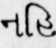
નહિ
